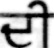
ਦੀ
